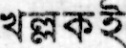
খল্লকই
